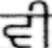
ਵੀ
